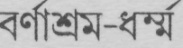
বৰ্ণাশ্ৰম-ধৰ্ম্ম
